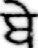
ਬੇ
